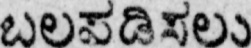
ಬಲಪಡಿಸಲು
